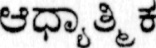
ಆಧ್ಯಾತ್ಮಿಕ
